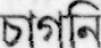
চাগনি
